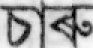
চাৰু
